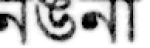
নঙনা
